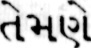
તેમણે
